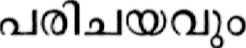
പരിചയവും
